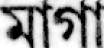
মাগা
